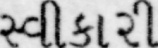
સ્વીકારી
